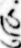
હું
